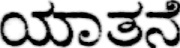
ಯಾತನೆ
